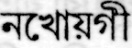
নখোয়গী
